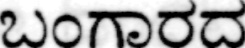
ಬಂಗಾರದ
